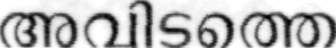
അവിടത്തെ
